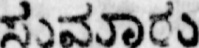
ಸುಮಾರು
